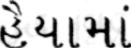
હૈયામાં
